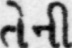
તેની
